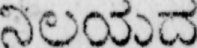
ನಿಲಯದ
